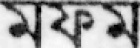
মফম
